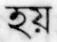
হয়
